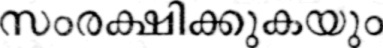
സംരക്ഷിക്കുകയും
